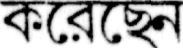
করেছেন
